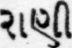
રાણી
